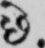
છે.
